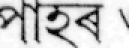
পাহৰ
